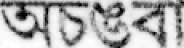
অচঙবা
